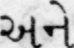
અને
